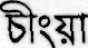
চীংয়া
